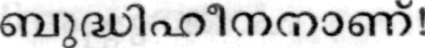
ബുദ്ധിഹീനനാണ്!
